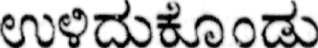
ಉಳಿದುಕೊಂಡು
